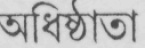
অধিষ্ঠাতা
